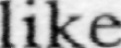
like
